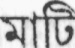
মাটি
